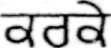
ਕਰਕੇ
